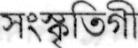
সংস্কৃতিগী
